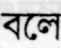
বলে
